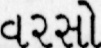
વરસો
